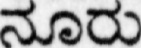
ನೂರು
